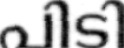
പിടി
